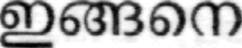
ഇങ്ങനെ
